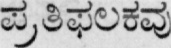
ಪ್ರತಿಫಲಕವು
